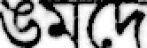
ঙমদে
